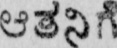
ಆತನಿಗೆ
